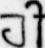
ਹੀ
